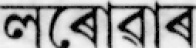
লৰোৱাৰ
